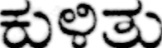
ಕುಳಿತು
